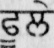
ਫੂਲੇ
